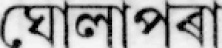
ঘোলাপৰা
